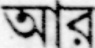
আর
